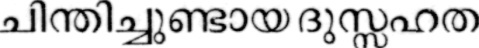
ചിന്തിച്ചുണ്ടായദുസ്സഹത
